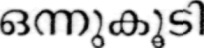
ഒന്നുകൂടി
